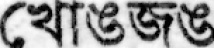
খোঙজৎ
